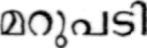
മറുപടി
